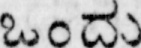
ಒಂದು
